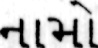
નામો
